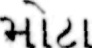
મોટા
